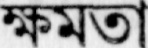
ক্ষমতা
